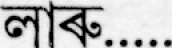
লাৰু.....
